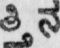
ತ್ತಿನ
